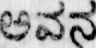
ಅವನ
